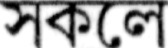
সকলে
